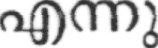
എന്നു
